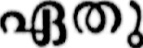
ഏതു
